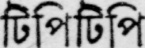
টিপিটিপি
